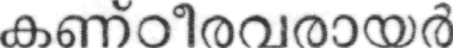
കണ്ഠീരവരായര്‍
